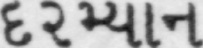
દરમ્યાન
